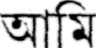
আমি
